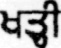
ਖੜ੍ਹੀ
